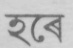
হৰে
